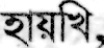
হায়খি,
